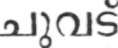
ചുവട്
